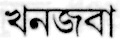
খনজবা
